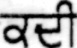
ਕਦੀ
